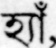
হ্যাঁ,
